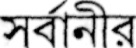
সর্বানীর
